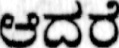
ಆದರೆ
